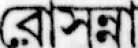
রোসন্না
